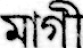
মাগী
